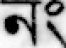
নং
